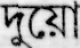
দুয়ো
